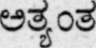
ಅತ್ಯಂತ
